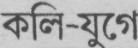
কলি-যুগে
